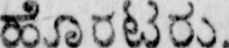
ಹೊರಟರು.
